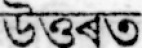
উত্তৰত
